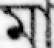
মা
